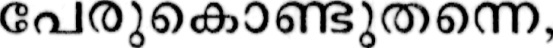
പേരുകൊണ്ടുതന്നെ,
